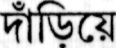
দাঁড়িয়ে
